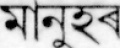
মানুহৰ
